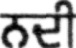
ਨਦੀ
